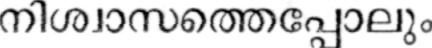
നിശ്വാസത്തെപ്പോലും
